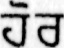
ਹੋਰ
